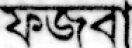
ফজবা
